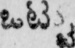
ಒಟ್ಟು
